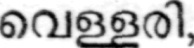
വെള്ളരി,
